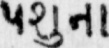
પશુના
